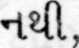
નથી,
